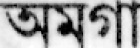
অমগা
